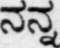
ನನ್ನ
